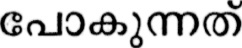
പോകുന്നത്
